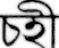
চহী
